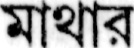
মাথার
